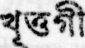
খূত্তগী
